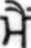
ਮੈਂ
